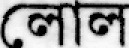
লোল
